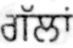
ਗੱਲਾਂ
